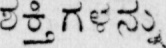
ಶಕ್ತಿಗಳನ್ನು
